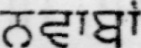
ਨਵਾਬਾਂ
